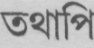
তথাপি
